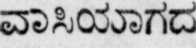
ವಾಸಿಯಾಗದ
